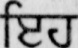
ਇਹ
